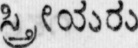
ಸ್ತ್ರೀಯರು
